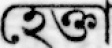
হেক্তা
